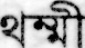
থম্মী
